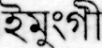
ইমুংগী
